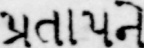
પ્રતાપને
